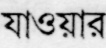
যাওয়ার
